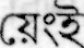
য়েংই
